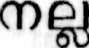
നല്ല
